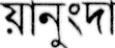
য়ানুংদা
